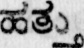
ಹತ್ತು
